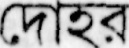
দোহর
